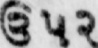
ઉપર
